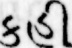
કહી
